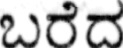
ಬರೆದ
